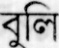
বুলি
